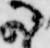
જે
